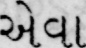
એવા
